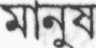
মানুষ
